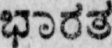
ಭಾರತ
